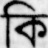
কি
